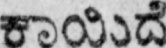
ಕಾಯಿದೆ
